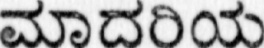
ಮಾದರಿಯ
